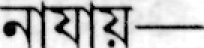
নাযায়-
